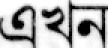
এখন
